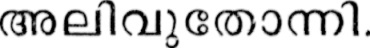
അലിവുതോന്നി.
